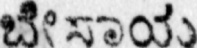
ಬೇಸಾಯ
